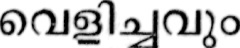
വെളിച്ചവും
